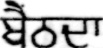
ਬੈਠਦਾ
